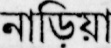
নাড়িয়া
